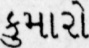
કુમારો
